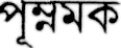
পূম্নমক
